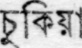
চুকিয়া
